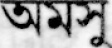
অমসু
